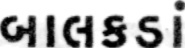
બાલકડાં
